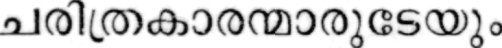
ചരിത്രകാരന്മാരുടേയും
